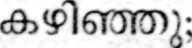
കഴിഞ്ഞു;
